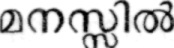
മനസ്സില്‍
